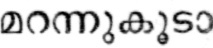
മറന്നുകൂടാ
